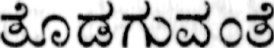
ತೊಡಗುವಂತೆ
